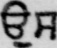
ਉਸ
